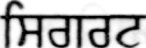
ਸਿਗਰਟ
